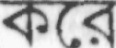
করে
